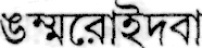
ঙম্মরোইদবা
